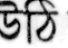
উঠি
